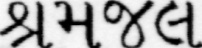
શ્રમજલ
